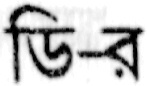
ডি-র
